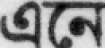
এনে
